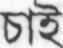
চাই
